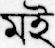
মই
